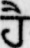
ਹੈ
